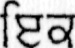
ਇਕ
